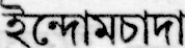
ইন্দোমচাদা
